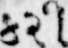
કરી
